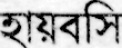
হায়বসি
